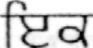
ਇਕ
